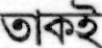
তাকই
